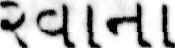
રવાના
